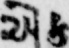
એક
